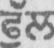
ਫੁੱਲ
